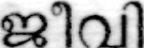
ജീവി
